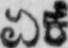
ಏಕೆ
